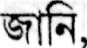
জানি,
